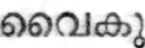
വൈകു
